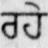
ਰਹੇ
